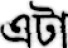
এটা
